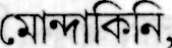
মোন্দাকিনি,
